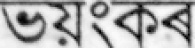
ভয়ংকৰ
